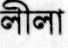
লীলা
